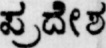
ಪ್ರದೇಶ
